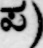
ಪ)
